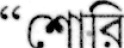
“শোরি
